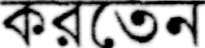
করতেন
